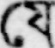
যে
